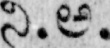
ನಿ.ಅ.
